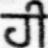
ਹੀ
